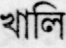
খালি
